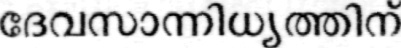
ദേവസാന്നിധ്യത്തിന്
